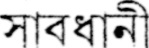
সাবধানী
